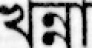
খন্না
